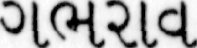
ગભરાવ
